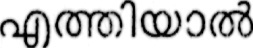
എത്തിയാല്‍
